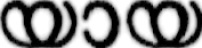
യായ
